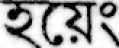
হয়েং
